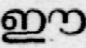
ഈ
